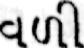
વળી
